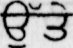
ਉੱਤੇ
